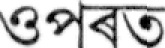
ওপৰত
